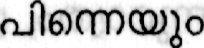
പിന്നെയും
